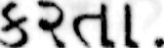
કરતા.
